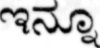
ಇನ್ನೂ
